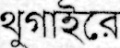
থুগাইরে
